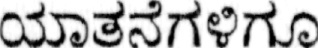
ಯಾತನೆಗಳಿಗೂ
